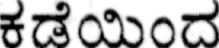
ಕಡೆಯಿಂದ
